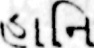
હાનિ
